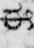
ಈ
